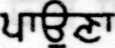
ਪਾਉਣਾ
